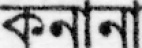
কনানা
